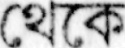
থেকে
